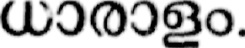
ധാരാളം.
